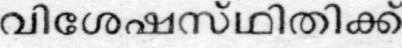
വിശേഷസ്ഥിതിക്ക്
